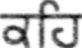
ਕਹਿ
